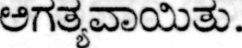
ಅಗತ್ಯವಾಯಿತು.
